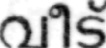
വീട്
